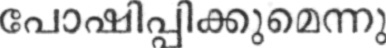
പോഷിപ്പിക്കുമെന്നു
